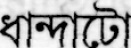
ধান্দাটো
